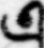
এ
